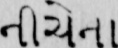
નીચેના
